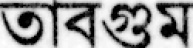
তাবগুম
